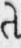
તે
